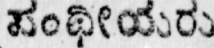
ಪಂಥೀಯರು
